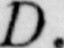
D.
